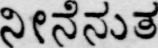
ನೀನೆನುತ
